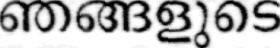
ഞങ്ങളുടെ
